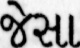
જેસા
